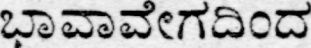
ಭಾವಾವೇಗದಿಂದ
